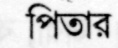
পিতার
